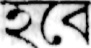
হবে
